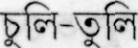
চুলি-তুলি
